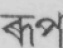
ৰূপ
